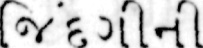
જિંદગીની
